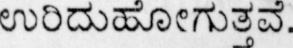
ಉರಿದುಹೋಗುತ್ತವೆ.
